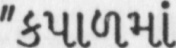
"કપાળમાં
